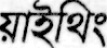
য়াথিং
